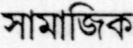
সামাজিক
